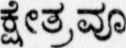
ಕ್ಷೇತ್ರವೂ
